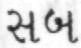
સબ
